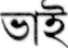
ভাই
